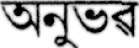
অনুভৱ
